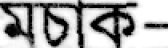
মচাক-
